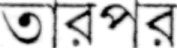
তারপর
